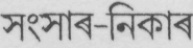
সংসাৰ-নিকাৰ
